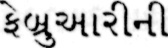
ફેબ્રુઆરીની
